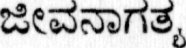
ಜೀವನಾಗತ್ಯ
